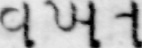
વખત
